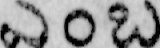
ಎಂಬ
